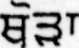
ਥੋੜਾ
